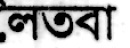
লৈতবা
